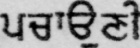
ਪਚਾਉਣੀ
